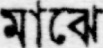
মাঝে
